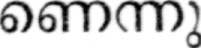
ണെന്നു
